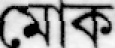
মোক
